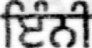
ਇੰਨੀ
